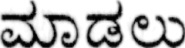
ಮಾಡಲು
